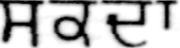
ਸਕਦਾ
